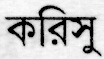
করিসু
